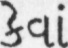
કેવાં
